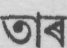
তাৰ
